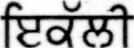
ਇਕੱਲੀ
